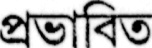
প্রভাবিত
